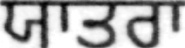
ਯਾਤਰਾ
